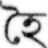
হৈ
